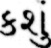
કશું
